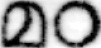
മം
